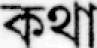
কথা
